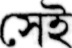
সেই
